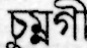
চুম্নগী
